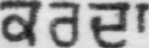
ਕਰਦਾ
